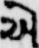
એ
